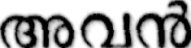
അവന്‍
